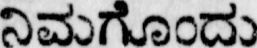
ನಿಮಗೊಂದು
